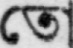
তো
